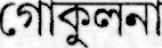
গোকুলনা
